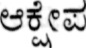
ಆಕ್ಷೇಪ
